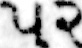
પર
